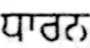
ਧਾਰਨ
